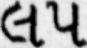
લપ
